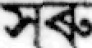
সৰু
